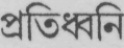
প্রতিধ্বনি
